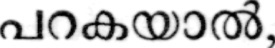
പറകയാല്‍,
